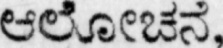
ಆಲೋಚನೆ,
